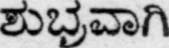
ಶುಭ್ರವಾಗಿ
